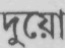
দুয়ো
